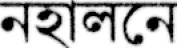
নহালনে
